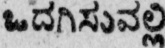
ಒದಗಿಸುವಲ್ಲಿ
